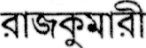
রাজকুমারী
